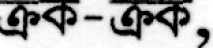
ক্রক-ক্রক,
